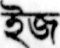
ইজ
